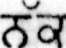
ਨੱਕ
